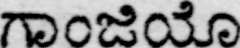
ಗಾಂಜಿಯೊ
